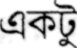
একটু
